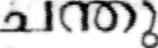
ചന്തു
